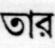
তার
